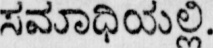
ಸಮಾಧಿಯಲ್ಲಿ.
